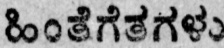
ಹಿಂತೆಗೆತಗಳು
